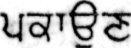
ਪਕਾਉਣ
